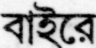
বাইরে
